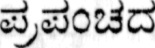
ಪ್ರಪಂಚದ
